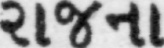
રાજના
